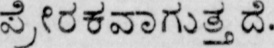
ಪ್ರೇರಕವಾಗುತ್ತದೆ.
